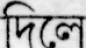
দিলে
